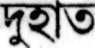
দুহাত
